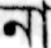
না
